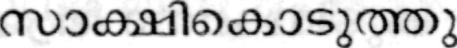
സാക്ഷികൊടുത്തു
